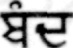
ਬੰਦ
